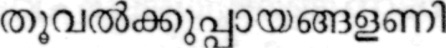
തൂവല്‍ക്കുപ്പായങ്ങളണി
